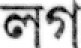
লগ
